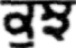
ਕੁਝ
